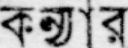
কন্যার
